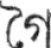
গৈ
